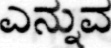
ಎನ್ನುವ
